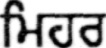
ਮਿਹਰ
